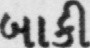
બાકી
